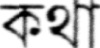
কথা
